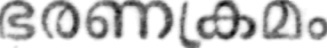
ഭരണക്രമം
